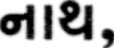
નાથ,
